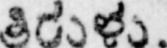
ತಿರುಳು.
